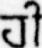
ਹੀ
